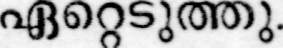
ഏറ്റെടുത്തു.
